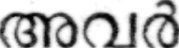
അവര്‍
